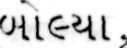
બોલ્યા,
